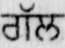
ਗੱਲ
